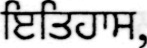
ਇਤਿਹਾਸ,
